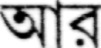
আর
